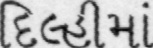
દિલ્હીમાં
